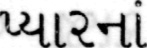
પ્યારનાં
